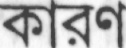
কারণ
